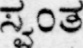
ಸ್ವಂತ
